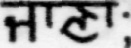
ਜਾਣਾ;
